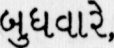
બુધવારે,
